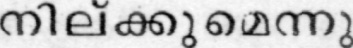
നില്ക്കുമെന്നു
